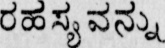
ರಹಸ್ಯವನ್ನು
